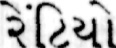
રેંટિયો
